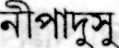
নীপাদুসু
